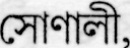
সোণালী,
